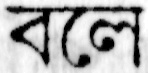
বলে
